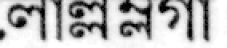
লোলম্লগা
